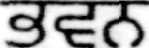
ਭਵਨ
